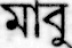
মাবু
